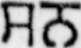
ਸਨ
